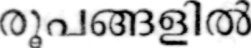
രൂപങ്ങളില്‍
